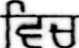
ਵਿਚ
